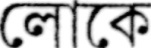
লোকে
